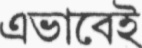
এভাবেই
